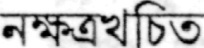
নক্ষত্রখচিত
